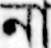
না
